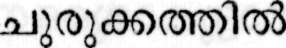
ചുരുക്കത്തില്‍
